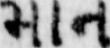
માન
